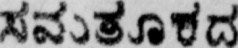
ಸಮತೂಕದ
